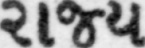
રાજ્ય
